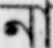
না
